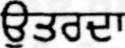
ਉਤਰਦਾ
